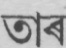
তাৰ
